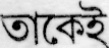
তাকেই
